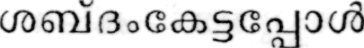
ശബ്ദംകേട്ടപ്പോള്‍
